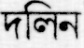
দলিন
